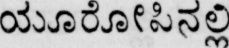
ಯೂರೋಪಿನಲ್ಲಿ
